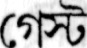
গেস্ট
